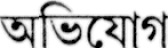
অভিযোগ
